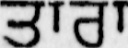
ਤਾਰਾ
